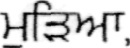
ਮੁੜਿਆ,
